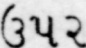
ઉપર
